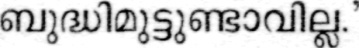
ബുദ്ധിമുട്ടുണ്ടാവില്ല.’
